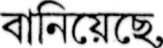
বানিয়েছে,
